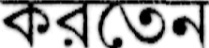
করতেন
